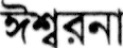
ঈশ্বরনা
